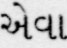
એવા
